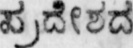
ಪ್ರದೇಶದ
